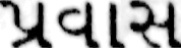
પ્રવાસ
